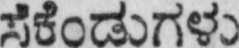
ಸೆಕೆಂಡುಗಳು
